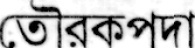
তৌরকপদা
